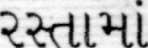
રસ્તામાં
